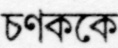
চণককে
